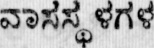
ವಾಸಸ್ಥಳಗಳ
